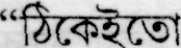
"ঠিকেইতো
